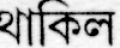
থাকিল
